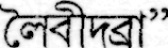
লৈবীদব্রা”
